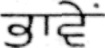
ਭਾਵੇਂ
